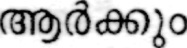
ആര്‍ക്കും
